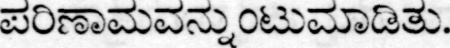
ಪರಿಣಾಮವನ್ನುಂಟುಮಾಡಿತು.
